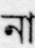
না
